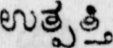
ಉತ್ಪತ್ತಿ
